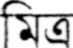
মিত্র
